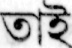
তাই
